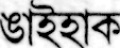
ঙাইহাক
